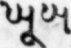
ખૂબ
